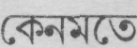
কেনমতে
